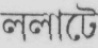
ললাটে
